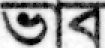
ভাব
